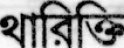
থারিক্তি
